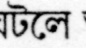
ঘটলে
